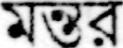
মন্তর
